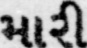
મારી
